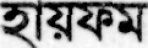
হায়ফম
